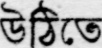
উঠিতে
